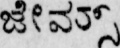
ಜೇಮ್ಸ್
